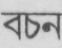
বচন
